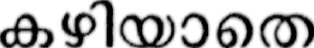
കഴിയാതെ
